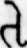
તે
